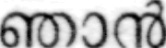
ഞാന്‍
